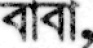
বাবা,
